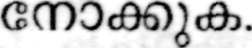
നോക്കുക.
